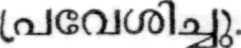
പ്രവേശിച്ചു.
